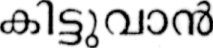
കിട്ടുവാന്‍
